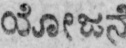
ಯೋಜನೆ
